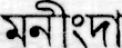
মনীংদা
